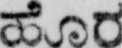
ಹೊರ
